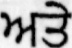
ਅਤੇ
